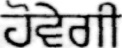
ਹੋਵੇਗੀ
